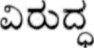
ವಿರುದ್ಧ
